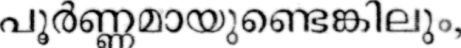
പൂര്‍ണ്ണമായുണ്ടെങ്കിലും,
